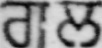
ਗਲ
